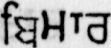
ਬਿਮਾਰ
